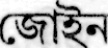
জোইন
